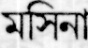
মসিনা
